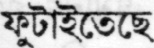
ফুটাইতেছে
